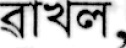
ৱাখল,
